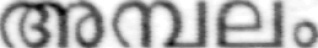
അമ്പലം
